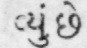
આવ્યુંછે
